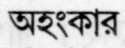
অহংকার
